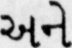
અને
